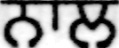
ਨਾਲ
